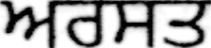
ਅਰਸਤ
